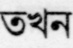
তখন
